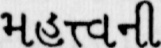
મહત્ત્વની
